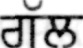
ਗੱਲ
